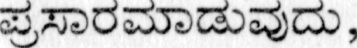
ಪ್ರಸಾರಮಾಡುವುದು,
